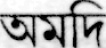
অমদি
